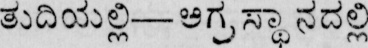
ತುದಿಯಲ್ಲಿ-ಅಗ್ರಸ್ಥಾನದಲ್ಲಿ
